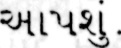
આપશું.
